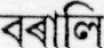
বৰালি
